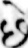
છે
